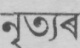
নৃত্যৰ
